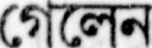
গেলেন
